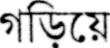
গড়িয়ে
